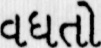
વધતો
